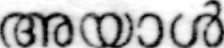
അയാള്‍
